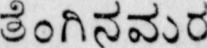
ತೆಂಗಿನಮರ
